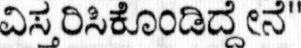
ವಿಸ್ತರಿಸಿಕೊಂಡಿದ್ದೇನೆ”
